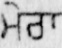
ਮੇਰਾ
